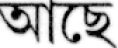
আছে
